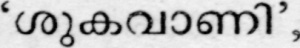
'ശുകവാണി',
